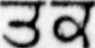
ਤਕ
